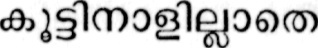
കൂട്ടിനാളില്ലാതെ
